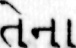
તેના
